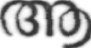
ആ
